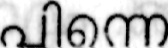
പിന്നെ
